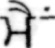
ਮੈਂ
